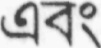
এবং
